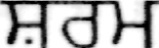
ਸ਼ਰਮ
